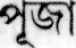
পূজা
